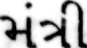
મંત્રી
